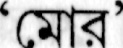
‘মোর’
